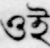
ওই
